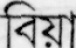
বিয়া
